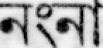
নংনা
